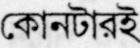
কোনটারই
